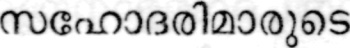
സഹോദരിമാരുടെ
